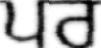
ਪਰ
